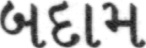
બદામ
